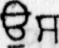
ਉਸ
